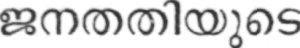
ജനതതിയുടെ
